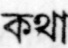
কথা
